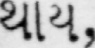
થાય,
